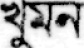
খুমন
